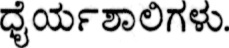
ಧೈರ್ಯಶಾಲಿಗಳು.
